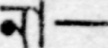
না—
